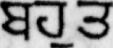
ਬਹੁਤ
